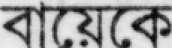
বায়েকে
